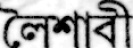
লৈশাবী
